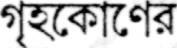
গৃহকোণের
